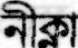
নীক্না
